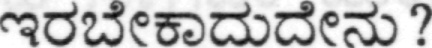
ಇರಬೇಕಾದುದೇನು?
